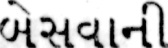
બેસવાની
